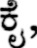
ಕೈ,
